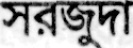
সরজুদা
